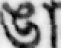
ঙা
